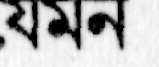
যেমন
